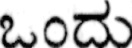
ಒಂದು
